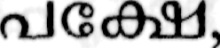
പക്ഷേ,
